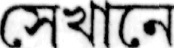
সেখানে
